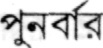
পুনর্বার
